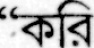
“করি
